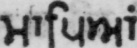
ਮਾਪਿਆਂ
